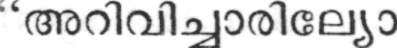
"അറിവിച്ചാരില്യോ
